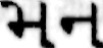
મન
